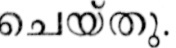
ചെയ്തു.
